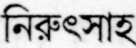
নিরুত্সাহ
